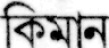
কিমান
